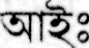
আইঃ
